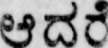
ಆದರೆ
